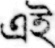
এই
